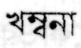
খম্বনা
